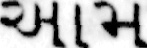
આમ
